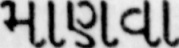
માણવા
